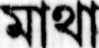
মাথা
